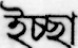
ইচ্ছা
